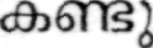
കണ്ടു
